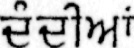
ਦੰਦੀਆਂ
